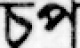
চপ
